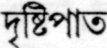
দৃষ্টিপাত
